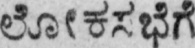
ಲೋಕಸಭೆಗೆ
